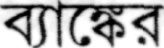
ব্যাঙ্কের
